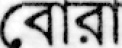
বোরা
